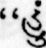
"હું
